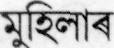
মুহিলাৰ
